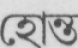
হোন্ত
